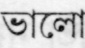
ভালো
